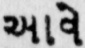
આવે
